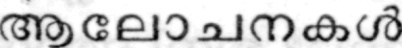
ആലോചനകള്‍
